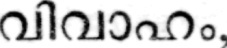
വിവാഹം,
